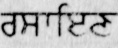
ਰਸਾਇਣ
